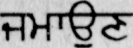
ਜਮਾਉਣ
